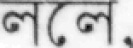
ললে,
